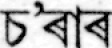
চ'ৰাৰ
